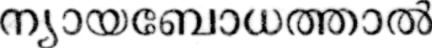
ന്യായബോധത്താല്‍
